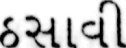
ઠસાવી
